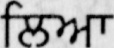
ਲਿਆ
